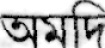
অমদি
